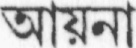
আয়না
